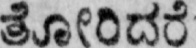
ತೋರಿದರೆ
